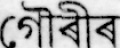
গৌৰীৰ
